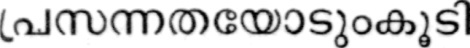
പ്രസന്നതയോടുംകൂടി
